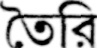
তৈরি
